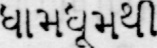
ધામધૂમથી
